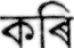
কৰি
